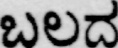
ಬಲದ
